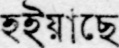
হইয়াছে
